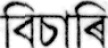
বিচাৰি
